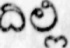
ದಿಲ್ಲಿ
